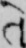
તે
